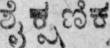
ಶೈಕ್ಷಣಿಕ
